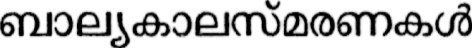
ബാല്യകാലസ്മരണകള്‍
